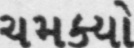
ચમક્યો
